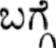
ಬಗ್ಗೆ
